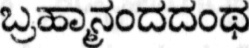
ಬ್ರಹ್ಮಾನಂದದಂಥ
